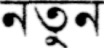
নতুন
